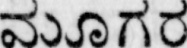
ಮೂಗರ
